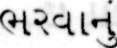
ભરવાનું
